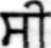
ਸੀ
